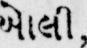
બોલી,
